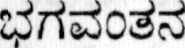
ಭಗವಂತನ
